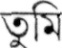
তুমি
